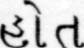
હોત
